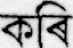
কৰি
